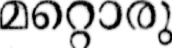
മറ്റൊരു
